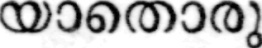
യാതൊരു
